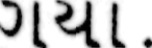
ગયા.
